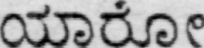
ಯಾರೋ
